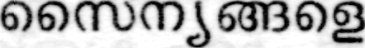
സൈന്യങ്ങളെ
